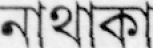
নাথাকা
